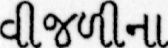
વીજળીના
